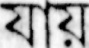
যায়
